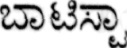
ಬಾಟಿಸ್ಟಾ
